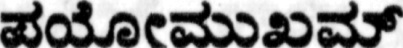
ಪಯೋಮುಖಮ್
